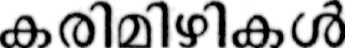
കരിമിഴികള്‍
